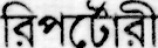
রিপর্টোরী
